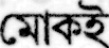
মোকই
